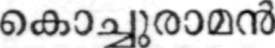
കൊച്ചുരാമന്‍
